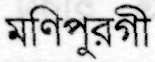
মণিপুরগী
